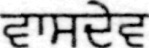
ਵਾਸਦੇਵ
